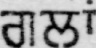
ਗਲਾਂ
